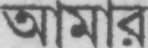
আমার
